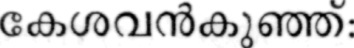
കേശവന്‍കുഞ്ഞ്:
